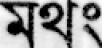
মথং
